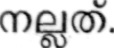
നല്ലത്.
